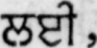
ਲਈ,
